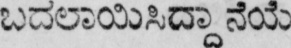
ಬದಲಾಯಿಸಿದ್ದಾನೆಯೆ
